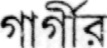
গার্গীর
